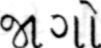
જાગો
